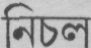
নিচল
